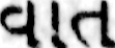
વાત
